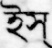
ইস্
